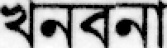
ওইরে
